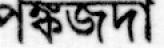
পঙ্কজদা
